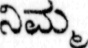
ನಿಮ್ಮ
